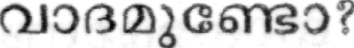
വാദമുണ്ടോ?
